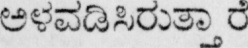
ಅಳವಡಿಸಿರುತ್ತಾರೆ.
